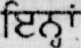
ਇਨ੍ਹਾਂ
